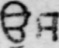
ਉਸ
